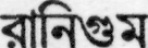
রানিগুম
